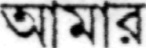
আমার
